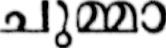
ചുമ്മാ
